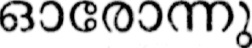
ഓരോന്നു
